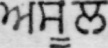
ਅਸੂਲ
